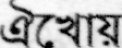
ঐখোয়
